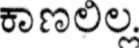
ಕಾಣಲಿಲ್ಲ.
